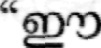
“ഈ
